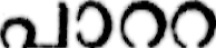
പാററ
